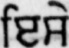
ਇਸੇ
